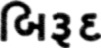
બિરૂદ
